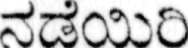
ನಡೆಯಿರಿ
